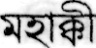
মহাক্কী
